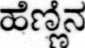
ಹೆಣ್ಣಿನ
